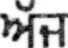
ਅੱਜ
